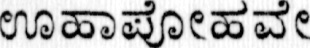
ಊಹಾಪೋಹವೇ
